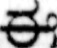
ಈ
